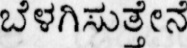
ಬೆಳಗಿಸುತ್ತೇನೆ
